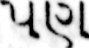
પણ
